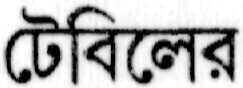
টেবিলের
